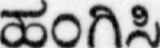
ಹಂಗಿಸಿ
